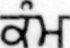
ਕੰਮ
